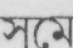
সমে
